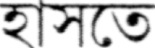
হাসতে
